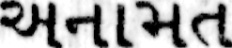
અનામત
